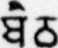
ਬੈਠ
